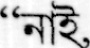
"নাই,
